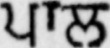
ਪਾਲ
